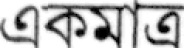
একমাত্র
